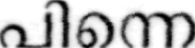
പിന്നെ
